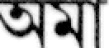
অমা
